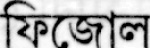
ফিজোল
